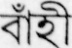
বাঁহী
